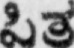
ಪಿತ
